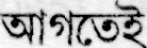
আগতেই
